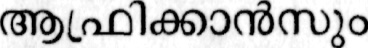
ആഫ്രിക്കാന്‍സും
